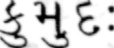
કુમુદઃ
